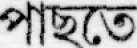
পাছতে
